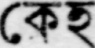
কেহ
